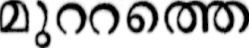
മുററത്തെ
